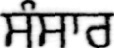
ਸੰਸਾਰ
